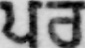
ਪਰ
